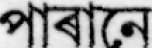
পাৰানে
